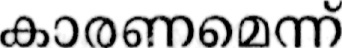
കാരണമെന്ന്
